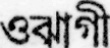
ওঝাগী
